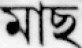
মাছ
